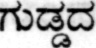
ಗುಡ್ಡದ
